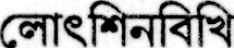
লোৎশিনবিখি
